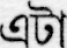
এটা
